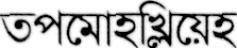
তপমোহখ্লিয়েহ
